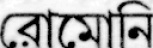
রোমোনি
